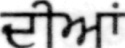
ਦੀਆਂ
